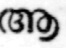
ആ
